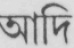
আদি
